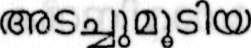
അടച്ചുമൂടിയ
